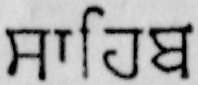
ਸਾਹਿਬ
